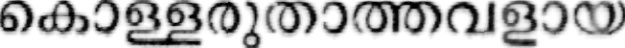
കൊള്ളരുതാത്തവളായ
